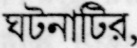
ঘটনাটির,
